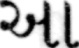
આ
